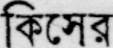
কিসের
